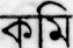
কমি
